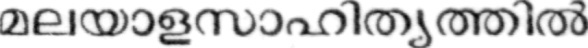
മലയാളസാഹിത്യത്തില്‍
